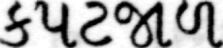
કપટજાળ
